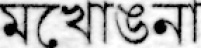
মখোঙনা
